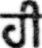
ਹੀ
